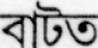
বাটত
